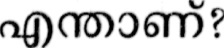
എന്താണ്?
